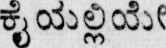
ಕೈಯಲ್ಲಿಯೇ
